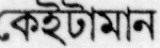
কেইটামান
